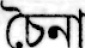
চৈনা
